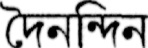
দৈনন্দিন
